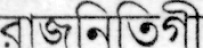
রাজনিতিগী
